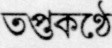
তপ্তকণ্ঠে
